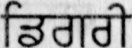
ਡਿਗਰੀ
